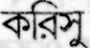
করিসু
